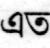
এত
